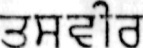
ਤਸਵੀਰ
